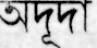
অদূগা
